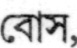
বোস,
